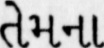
તેમના
